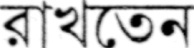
রাখতেন
